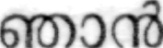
ഞാന്‍
